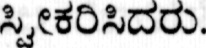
ಸ್ವೀಕರಿಸಿದರು.
